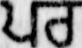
ਪਰ
